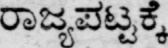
ರಾಜ್ಯಪಟ್ಟಕ್ಕೆ
